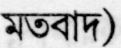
মতবাদ)
